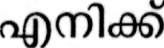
എനിക്ക്
